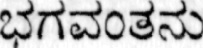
ಭಗವಂತನು
